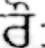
ਰੌ:
